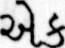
એક
